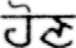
ਹੋਣ
